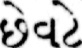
છેવટે
